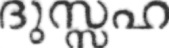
ദുസ്സഹ
